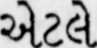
એટલે
